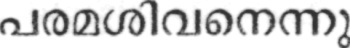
പരമശിവനെന്നു
